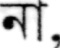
না,
